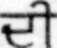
ਦੀ
